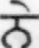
ਨੇ
